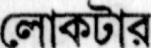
লোকটার
